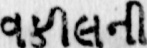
વકીલની
